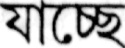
যাচ্ছে
